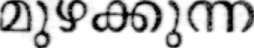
മുഴക്കുന്ന
